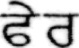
ਫੇਰ
